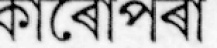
কাৰোপৰা
